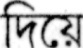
দিয়ে
